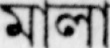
মালা
